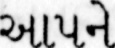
આપને
